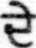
ਦੇ
